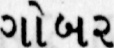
ગોબર
